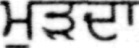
ਮੁੜਦਾ
